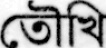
তৌখি
